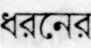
ধরনের
